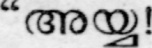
"അയ്യ!
